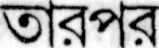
তারপর
